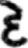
દે
